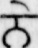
ਨੇ
